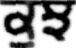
ਕੁਝ
